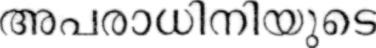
അപരാധിനിയുടെ
